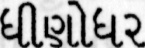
ધીણોધર
